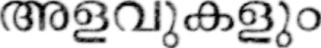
അളവുകളും
